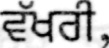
ਵੱਖਰੀ,
